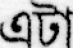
এটা
